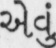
એવું
